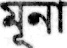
মূনা
